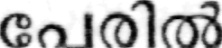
പേരില്‍
